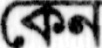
কেন
